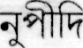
নুপীদি
